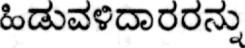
ಹಿಡುವಳಿದಾರರನ್ನು
